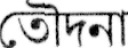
তৌদনা
